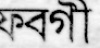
ফবগী
